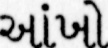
આંખો
